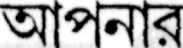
আপনার
